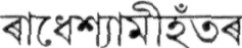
ৰাধেশ্যামীহঁতৰ
